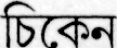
চিকেন
